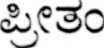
ಪ್ರೀತಂ
